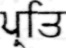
ਪ੍ਰਤਿ
